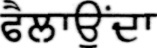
ਫੈਲਾਉਂਦਾ
